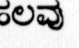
ಹಲವು
